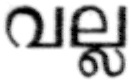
വല്ല
